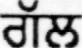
ਗੱਲ
